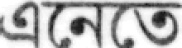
এনেতে
